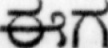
ಈಗ
